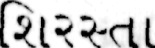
શિરસ્તા
